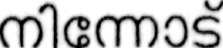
നിന്നോട്
